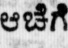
ಆಚೆಗೆ
